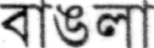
বাঙলা
